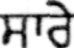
ਸਾਰੇ
